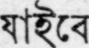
যাইবে
